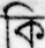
কি
